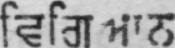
ਵਿਗਿਆਨ
